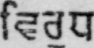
ਵਿਰੁਧ
